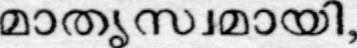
മാതൃസ്വമായി,
